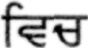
ਵਿਚ
